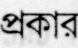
প্রকার
